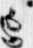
હું
